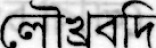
লৌখ্রবদি
